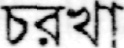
চরখা
